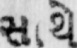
સાથએ
